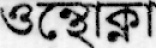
ওন্থোক্না
